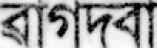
ৱাগদবা
